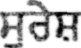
ਸੁਰੇਸ਼
